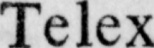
Telex
